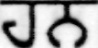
ਹਨ
